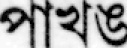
পাখঙ
